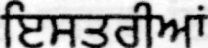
ਇਸਤਰੀਆਂ
